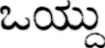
ಒಯ್ದು
